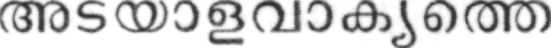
അടയാളവാക്യത്തെ
